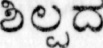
ಶಿಲ್ಪದ
